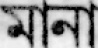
মানা
